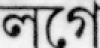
লগে
